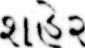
શહેર
